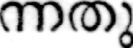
ന്നതു
